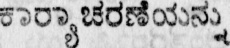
ಕಾರ್ಯಾಚರಣೆಯನ್ನು
